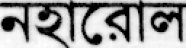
নহারোল
